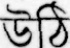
উঠি
